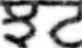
ਝਟ
